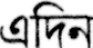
এদিন
